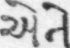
એને
